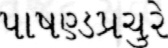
પાષણ્ડપ્રચુરે
